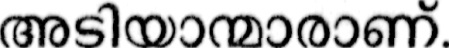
അടിയാന്മാരാണ്.
